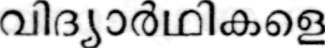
വിദ്യാര്‍ഥികളെ
